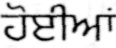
ਹੋਈਆਂ
